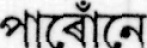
পাৰোঁনে
